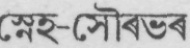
স্নেহ-সৌৰভৰ
